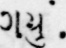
ગયું.
